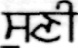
ਸੁਣੀ
